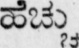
ಹೆಚ್ಚು
